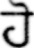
ਹੋ
